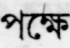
পক্ষে
